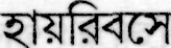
হায়রিবসে
